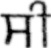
ਸੀ
